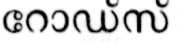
റോഡ്സ്
